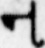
ન
